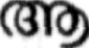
ആ
